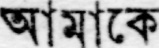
আমাকে
